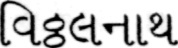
વિઠ્ઠલનાથ
